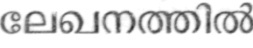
ലേഖനത്തില്‍
